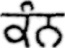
ਕੰਨ
